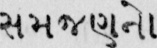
સમજણનો
